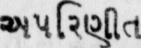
અપરિણીત
